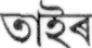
তাইৰ
